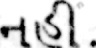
નહીં.
